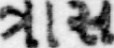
ત્રાસ
